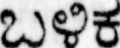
ಬಳಿಕ
